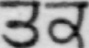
ਤਕ
